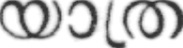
യാത്ര
